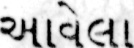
આવેલા
